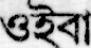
ওইবা
